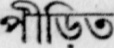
পীড়িত
